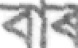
বাৰ
